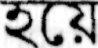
হয়ে
